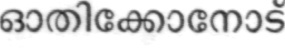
ഓതിക്കോനോട്
